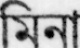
মিনা
